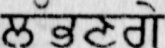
ਲੱਭਣਗੇ
